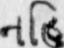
નહિ
